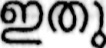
ഇതു
